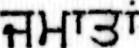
ਜਮਾਤਾਂ
